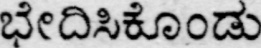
ಭೇದಿಸಿಕೊಂಡು
